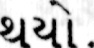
થયો.
